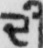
ਦੀ
